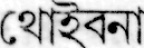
থোইবনা
